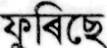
ফুৰিছে
